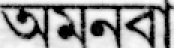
অমনবা
